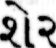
શેર
